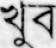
খুব
